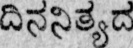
ದಿನನಿತ್ಯದ
